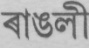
ৰাঙলী
